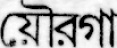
য়ৌরগা
